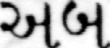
અબ
